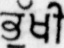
ਭੁੱਖੀ
